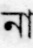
না
